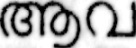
ആവ
